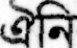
ঐনি
